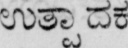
ಉತ್ಪಾದಕ
